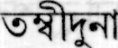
তম্বীদুনা
